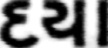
દયા
